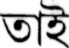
তাই
